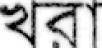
খরা
